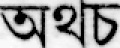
অথচ
